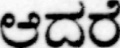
ಆದರೆ
